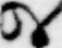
જ
